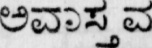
ಅವಾಸ್ತವ
